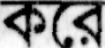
করে
